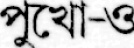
পুখো-ও
